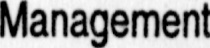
Management
